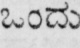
ಒಂದು
